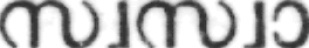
സ്വസ്വാ
